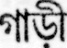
গাড়ী
